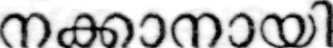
നക്കാനായി
